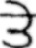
ਤੇ
